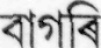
বাগৰি
